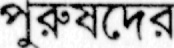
পুরুষদের
